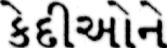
કેદીઓને
